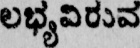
ಲಭ್ಯವಿರುವ
